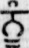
ਨੂੰ
